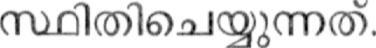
സ്ഥിതിചെയ്യുന്നത്.
